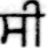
ਸੀ
